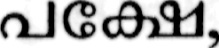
പക്ഷേ,
